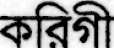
করিগী
